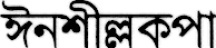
ঈনশীল্লকপা
